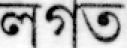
লগত
